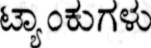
ಟ್ಯಾಂಕುಗಳು
